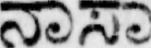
ನಾಸಾ
